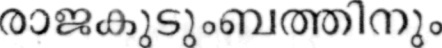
രാജകുടുംബത്തിനും
